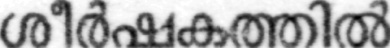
ശീര്‍ഷകത്തില്‍
